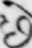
છે
